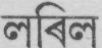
লৰিল
